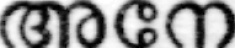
അനേ
